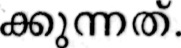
ക്കുന്നത്.
